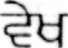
ਵੇਖ
